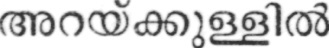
അറയ്ക്കുള്ളില്‍
